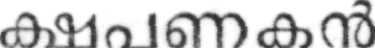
ക്ഷപണകന്‍
